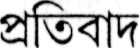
প্রতিবাদ
